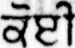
ਕੋਈ
